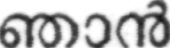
ഞാന്‍
